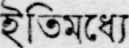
ইতিমধ্যে
